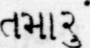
તમારું
